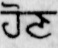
ਹੋਣ
